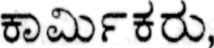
ಕಾರ್ಮಿಕರು,
